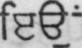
ਇਉਂ
